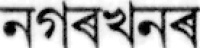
নগৰখনৰ
